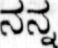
ನನ್ನ
